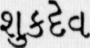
શુકદેવ
